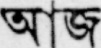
আজ
